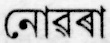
নোৱৰা
